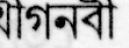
থীগনবী
